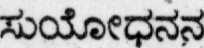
ಸುಯೋಧನನ
